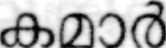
കമാര്‍
